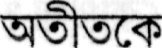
অতীতকে
